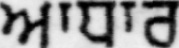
ਆਧਾਰ
